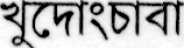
খুদোংচাবা
